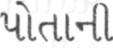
પોતાની
